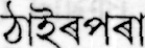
ঠাইৰপৰা
